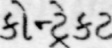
કોન્ટ્રેકટ
